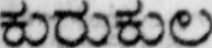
ಕುರುಕುಲ
